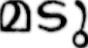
മടു
